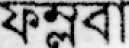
ফম্লবা
